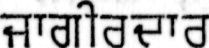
ਜਾਗੀਰਦਾਰ
